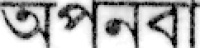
অপনবা
